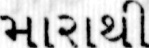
મારાથી
